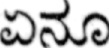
ಏನೂ
